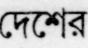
দেশের
